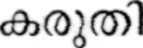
കരുതി
